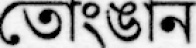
তোংঙান
